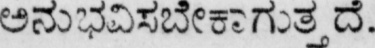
ಅನುಭವಿಸಬೇಕಾಗುತ್ತದೆ.
